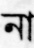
না
